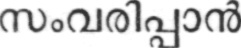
സംവരിപ്പാന്‍
